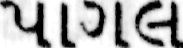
પાગલ
